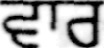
ਵਾਰ
